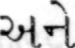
અને
